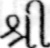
શ્રી
